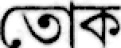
তোক
